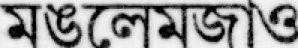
মঙলেমজাও
